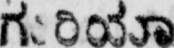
ಗುರಿಯಾ
